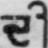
ਦੀ
